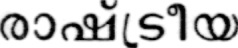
രാഷ്ട്രീയ
